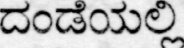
ದಂಡೆಯಲ್ಲಿ
